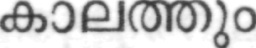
കാലത്തും
